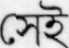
সেই
